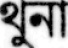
থুনা
